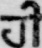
ਹੀ
